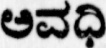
ಅವಧಿ
